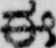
ಈ
